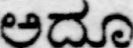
ಅದೂ
